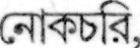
নোকচরি,
